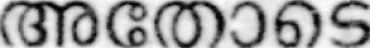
അതോടെ
